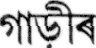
গাড়ীৰ
